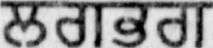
ਲਗਭਗ
